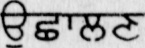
ਉਛਾਲਣ
